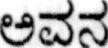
ಅವನ
